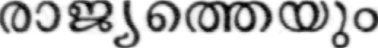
രാജ്യത്തെയും
